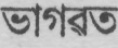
ভাগৱত
